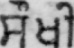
ਸੌਖੀ
